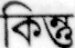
কিন্তু
